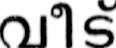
വീട്
